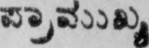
ಪ್ರಾಮುಖ್ಯ
